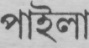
পাইলা
